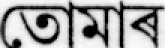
তোমাৰ
